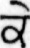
ਕੇ
